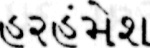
હરહંમેશ
